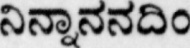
ನಿನ್ನಾನನದಿಂ
